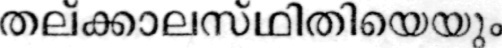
തല്ക്കാലസ്ഥിതിയെയും
